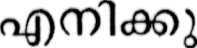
എനിക്കു
